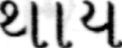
થાય
